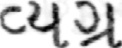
વ્યગ્ર
